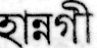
হান্নগী
